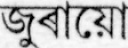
জুৰায়ো
